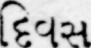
દિવસ
